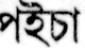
পইচা
